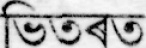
ভিতৰত
